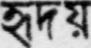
হৃদয়
